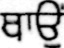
ਥਾਉਂ
